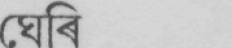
ঘেৰি
